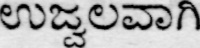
ಉಜ್ವಲವಾಗಿ
